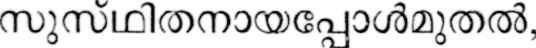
സുസ്ഥിതനായപ്പോള്‍മുതല്‍,
